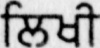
ਲਿਖੀ
